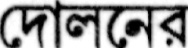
দোলনের
